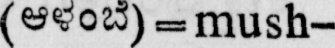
(ಆಳಂಬೆ)=mush-
